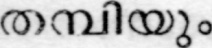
തമ്പിയും
